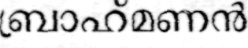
ബ്രാഹ്മണന്‍
